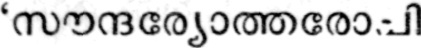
'സൗന്ദര്യോത്തരോപി
